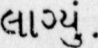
લાગ્યું.
